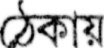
ঠেকায়
